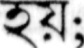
হয়;
